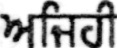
ਅਜਿਹੀ
